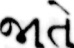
જાતે
